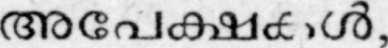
അപേക്ഷകള്‍,
